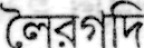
লৈরগদি
